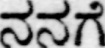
ನನಗೆ
